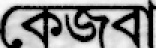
কেজবা
